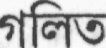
গলিত
